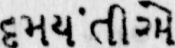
દમયંતીએ
